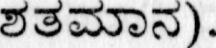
ಶತಮಾನ).
